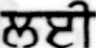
ਲਈ
